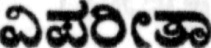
ವಿಪರೀತಾ
